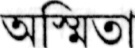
অস্মিতা
